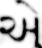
એ
